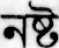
নষ্ট
